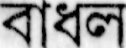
বাধল
